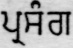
ਪ੍ਰਸੰਗ
